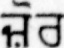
ਜ਼ੋਰ
